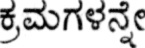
ಕ್ರಮಗಳನ್ನೇ
